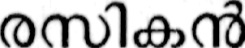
രസികന്‍
